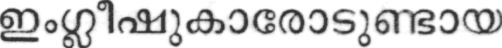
ഇംഗ്ലീഷുകാരോടുണ്ടായ
